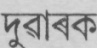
দুৱাৰক
